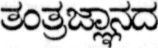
ತಂತ್ರಜ್ಞಾನದ
